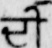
ਦੀ
